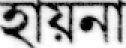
হায়না
